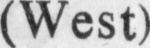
(West)
